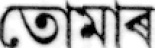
তোমাৰ
